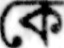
কে
